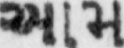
આમ
